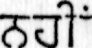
ਨਹੀਂ
